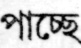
পাচ্ছে
